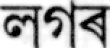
লগৰ
